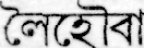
লৈহৌবা
